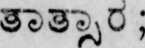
ತಾತ್ಸಾರ;
